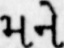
મને
